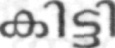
കിട്ടി
